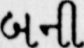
બની
